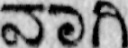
ವಾಗಿ
